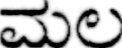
ಮಲ
